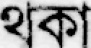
থকা
